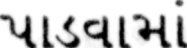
પાડવામાં
